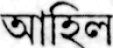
আহিল
